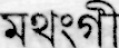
মথংগী
